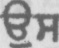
ਉਸ
